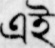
এই
